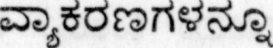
ವ್ಯಾಕರಣಗಳನ್ನೂ
